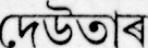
দেউতাৰ
